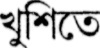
খুশিতে
